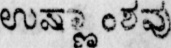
ಉಷ್ಣಾಂಶವು
